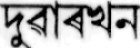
দুৱাৰখন
